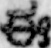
ಈ
